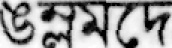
ঙম্লমদে
